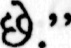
છે."
